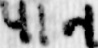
પાન
